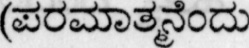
(ಪರಮಾತ್ಮನೆಂದು
